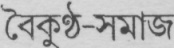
বৈকুণ্ঠ-সমাজ
